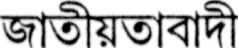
জাতীয়তাবাদী
